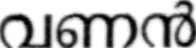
വണന്‍
